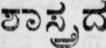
ಶಾಸ್ತ್ರದ
